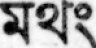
মথং
